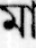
মা
